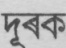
দূৰক
